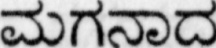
ಮಗನಾದ
